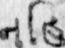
નહિ
